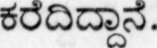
ಕರೆದಿದ್ದಾನೆ.
